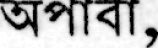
অপাবা,
